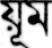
য়ূম
